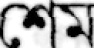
শেম
